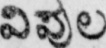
ವಿಪುಲ
